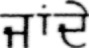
ਜਾਂਦੇ
